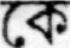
কে
